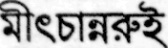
মীৎচান্নরুই
